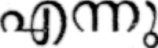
എന്നു
